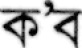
ক'ব
